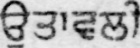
ਉਤਾਵਲੀ
